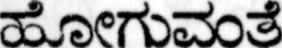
ಹೋಗುವಂತೆ
